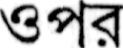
ওপর
